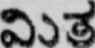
ಮಿತ
